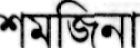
শমজিনা
